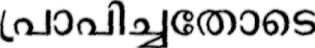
പ്രാപിച്ചതോടെ
